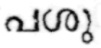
പശു
